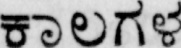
ಕಾಲಗಳ
